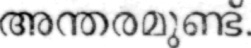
അന്തരമുണ്ട്.
